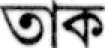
তাক
